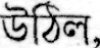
উঠিল,
